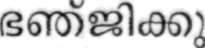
ഭഞ്ജിക്കു
